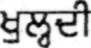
ਖੁਲ੍ਹਦੀ
